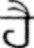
ਹੈ
